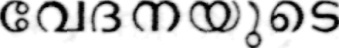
വേദനയുടെ
